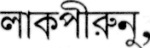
লাকপীরুনু,
